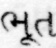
ભૂત
